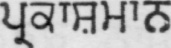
ਪ੍ਰਕਾਸ਼ਮਾਨ
